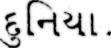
દુનિયા.
